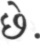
છે.
